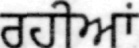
ਰਹੀਆਂ
